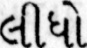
લીધો
